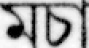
মচা
